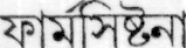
ফার্মসিষ্টনা
